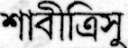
শাবীত্রিসু
